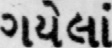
ગયેલાં
